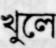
খুলে
